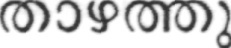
താഴത്തു
